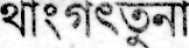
থাংগৎতুনা
